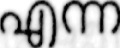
എന്ന
